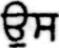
ਉਸ
